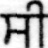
ਸੀ
